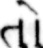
તો
